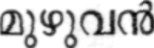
മുഴുവന്‍
